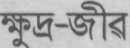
ক্ষুদ্ৰ-জীৱ
